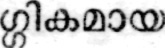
ഗ്ഗികമായ
